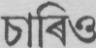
চাৰিও
